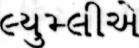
લ્યુમ્લીએ
